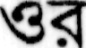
ওর
